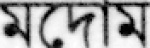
মদোম
